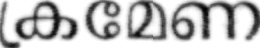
ക്രമേണ
